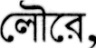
লৌরে,
